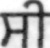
ਸੀ
